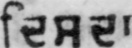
ਦਿਸਦਾ
